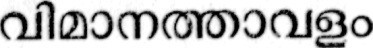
വിമാനത്താവളം
